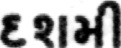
દશમી
